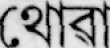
থোৱা
